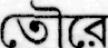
তৌরে
